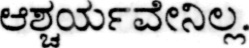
ಆಶ್ಚರ್ಯವೇನಿಲ್ಲ.
